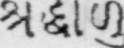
શ્રદ્ધાળુ
